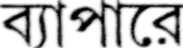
ব্যাপারে
